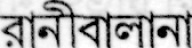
রানীবালানা
